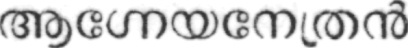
ആഗ്നേയനേത്രന്‍
